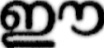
ഈ
